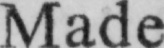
Made
